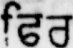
ਫਿਰ
